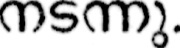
നടന്നു.
